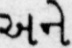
અને
